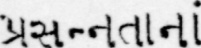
પ્રસન્નતાના
